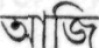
আজি
